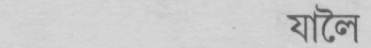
যালৈ
